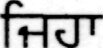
ਜਿਹਾ
